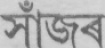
সাঁজৰ
